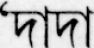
'দাদা
